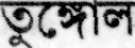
তুঙ্গোল
